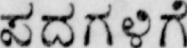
ಪದಗಳಿಗೆ
